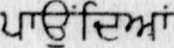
ਪਾਉਂਦਿਆਂ
